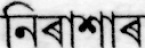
নিৰাশাৰ
